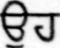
ਉਹ
